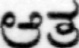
ಆತ
